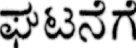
ಘಟನೆಗೆ
